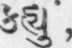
કહ્યું,
